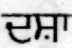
ਦਸ਼ਾ
